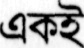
একই
